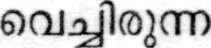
വെച്ചിരുന്ന
